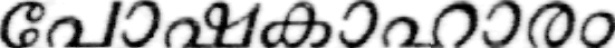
പോഷകാഹാരം
